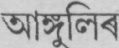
আঙ্গুলিৰ
